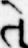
તે
